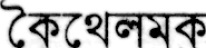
কৈথেলমক
